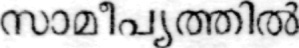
സാമീപ്യത്തില്‍
